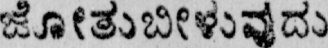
ಜೋತುಬೀಳುವುದು
